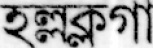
হল্লক্লগা
